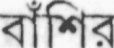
বাঁশির
